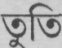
তুতি
